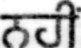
ਨਹੀਂ
